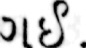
ગઈ.
